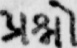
પશ્નો
